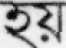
হয়
